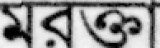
মরক্তা
